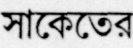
সাকেতের
